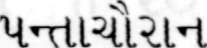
પન્તાચૌરાન
